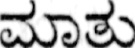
ಮಾತು
